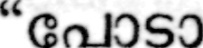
“പോടാ
